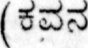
(ಕವನ
